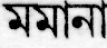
মমানা
